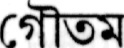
গৌতম
